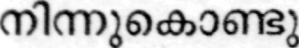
നിന്നുകൊണ്ടു
